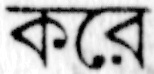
করে
